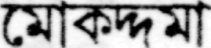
মোকদ্দমা
